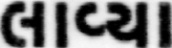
લાવ્યા
